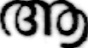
ആ
